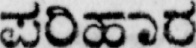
ಪರಿಹಾರ
